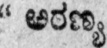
"ಅರಣ್ಯ
